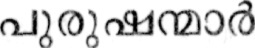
പുരുഷന്മാര്‍
